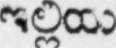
ಇಲ್ಲಿಯ
